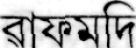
ৱাফমদি
